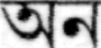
অন
